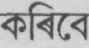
কৰিবে
